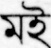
মই
